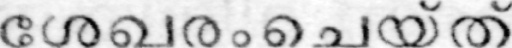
ശേഖരംചെയ്ത്
